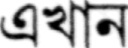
এখান
